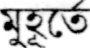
মুহূর্তে
